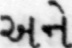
અને
